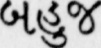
બહુજ
